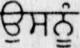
ਉਸਨੂੰ
